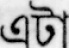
এটা
